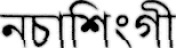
নচাশিংগী
